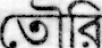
তৌরি
